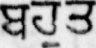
ਬਹੁਤ
